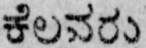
ಕೆಲವರು
